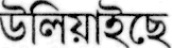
উলিয়াইছে
